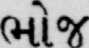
ભોજ
